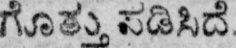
ಗೊತ್ತುಪಡಿಸಿದೆ.
